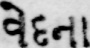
વેદના
